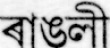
ৰাঙলী
